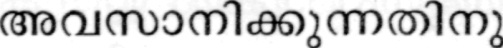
അവസാനിക്കുന്നതിനു
